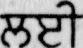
ਲਈ
